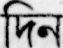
দিন
